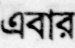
এবার
